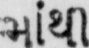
માંથી
